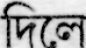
দিলে
